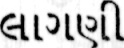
લાગણી
